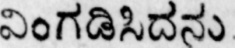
ವಿಂಗಡಿಸಿದನು.
